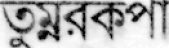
তুম্নরকপা
